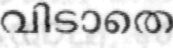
വിടാതെ
